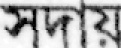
সদায়
